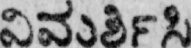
ವಿಮರ್ಶಿಸಿ
